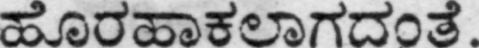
ಹೊರಹಾಕಲಾಗದಂತೆ.
